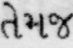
તેમજ
